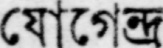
যোগেন্দ্র
